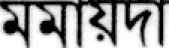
মমায়দা
